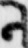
ને
